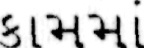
કામમાં
